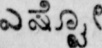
ಎಷ್ಟೋ
